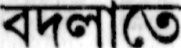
বদলাতে
